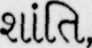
શાંતિ,
